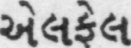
એલફેલ
